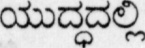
ಯುದ್ಧದಲ್ಲಿ
